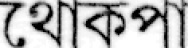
থোকপা
